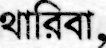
থারিবা,
